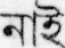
নাই
